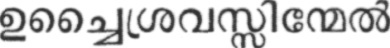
ഉച്ചൈശ്രവസ്സിന്മേല്‍
